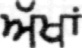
ਅੱਖਾਂ
